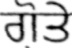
ਗ਼ੋਤੇ
